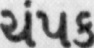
ચંપક
